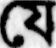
যে
